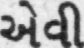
એવી
